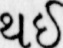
થઈ
